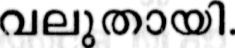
വലുതായി.
